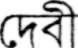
দেবী
